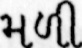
મળી
